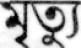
মৃত্যু
